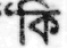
"কি
